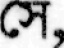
সে,
